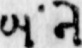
બંને
